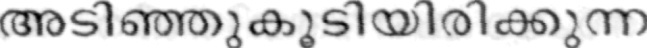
അടിഞ്ഞുകൂടിയിരിക്കുന്ന
